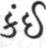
કંઈ
